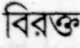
বিরক্ত
